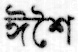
ঈশৈ
